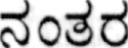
ನಂತರ
